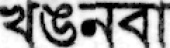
খঙনবা
